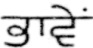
ਭਾਵੇਂ
